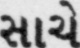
સાચે
